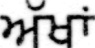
ਅੱਖਾਂ
